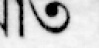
মাত
